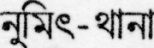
নুমিৎ-থানা
